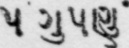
પગુપણું
